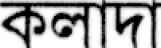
কলাদা
